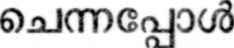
ചെന്നപ്പോള്‍
